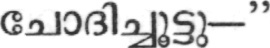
ചോദിച്ചൂട്ടു-"
